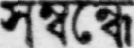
সম্বন্ধে
